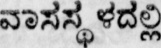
ವಾಸಸ್ಥಳದಲ್ಲಿ
